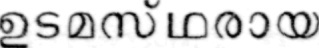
ഉടമസ്ഥരായ
